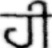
ਹੀ
